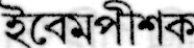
ইবেমপীশক
